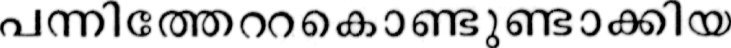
പന്നിത്തേററകൊണ്ടുണ്ടാക്കിയ
